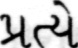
પ્રત્યે
